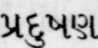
પ્રદુષણ
